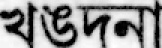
খঙদনা
